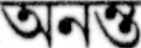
অনন্ত
